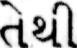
તેથી
